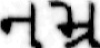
નમ્ર
